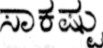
ಸಾಕಷ್ಟು
